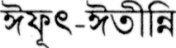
ঈফুৎ-ঈতীন্নি
